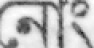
নোং
